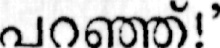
പറഞ്ഞ്!’
